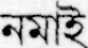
নমাই
